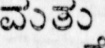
ಮತ್ತು
